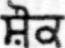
ਸ਼ੌਕ
